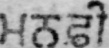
ਮਨਫ਼ੀ
